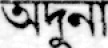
অদুনা
